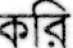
করি
